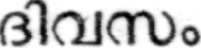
ദിവസം
